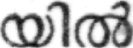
യില്‍
